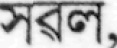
সৱল,
